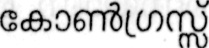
കോണ്‍ഗ്രസ്സ്
